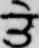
ਤੇ
